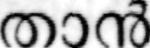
താന്‍
